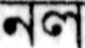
নল
